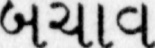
બચાવ
